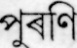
পুৰণি
